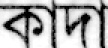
কাদা
